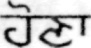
ਹੋਣਾ
